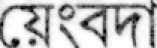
য়েংবদা
